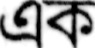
এক
